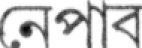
নেপাব
